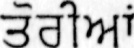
ਤੋਰੀਆਂ
